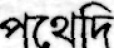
পথেদি
